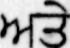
ਅਤੇ
